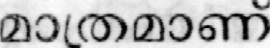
മാത്രമാണ്
